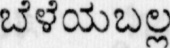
ಬೆಳೆಯಬಲ್ಲ
